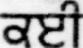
ਕਈ
